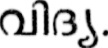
വിദ്യ.
